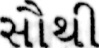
સૌથી
